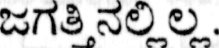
ಜಗತ್ತಿನಲ್ಲಿಲ್ಲ.
